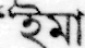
“ইমা
